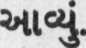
આવ્યું.
